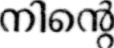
നിന്റെ
